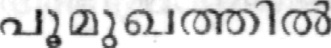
പൂമുഖത്തില്‍
